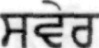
ਸਵੇਰ
